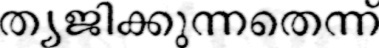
ത്യജിക്കുന്നതെന്ന്
